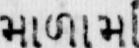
માળામાં
